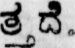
ತ್ತದೆ.
